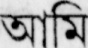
আমি
